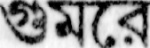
গুমরে
